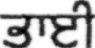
ਭਾਈ
